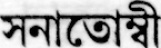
সনাতোম্বী
